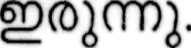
ഇരുന്നു.
